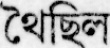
থৈছিল
